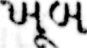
ખૂબ
